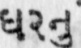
ઘરનું
